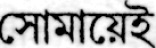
সোমায়েই
